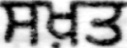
ਸਖ਼ਤ
